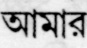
আমার
